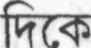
দিকে
